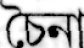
চৈনা
